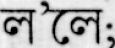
ল'লে;
